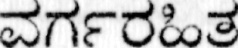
ವರ್ಗರಹಿತ
